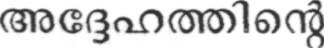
അദ്ദേഹത്തിന്റെ
